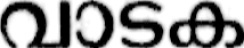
വാടക
